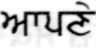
ਆਪਣੇ
